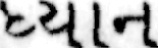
ધ્યાન
